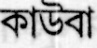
কাউবা
